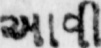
આવી
